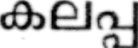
കലപ്പ
